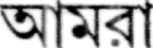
আমরা
